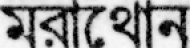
মরাথোন
